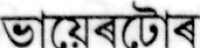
ভায়েৰটোৰ
